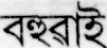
বহুৱাই
